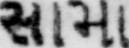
સામા
